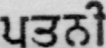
ਪਤਨੀ
